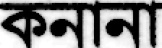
কনানা
